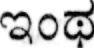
ಇಂಥ
